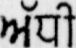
ਅੱਧੀ
